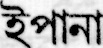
ইপানা
